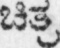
ಚಿತ್ರ
